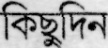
কিছুদিন
